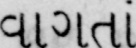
વાગતાં
